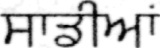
ਸਾਡੀਆਂ
